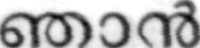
ഞാന്‍
